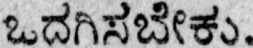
ಒದಗಿಸಬೇಕು.
